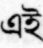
এই
